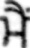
ਮੈਂ
